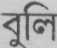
বুলি
